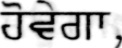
ਹੋਵੇਗਾ,
